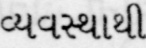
વ્યવસ્થાથી
